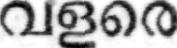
വളരെ
